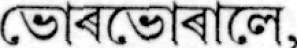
ভোৰভোৰালে,
